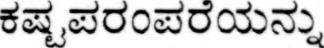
ಕಷ್ಟಪರಂಪರೆಯನ್ನು
